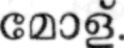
മോള്.
